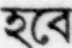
হবে
